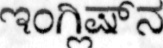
ಇಂಗ್ಲಿಷ್‌ನ
